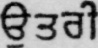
ਉਤਰੀ
